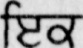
ਇਕ
